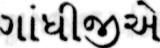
ગાંધીજીએ
